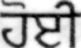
ਹੋਈ
